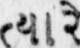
ત્યારે
